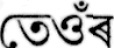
তেওঁৰ
